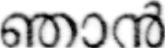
ഞാന്‍
